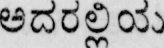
ಅದರಲ್ಲಿಯ
